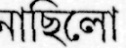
নাছিলো
